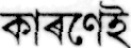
কাৰণেই
